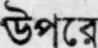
উপরে
